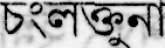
চংলক্তুনা
